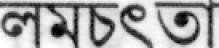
লমচৎতা
